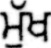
ਮੁੱਖ
